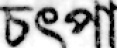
চৎপা
